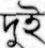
দুই
